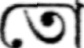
তো
